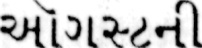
ઑગસ્ટની
